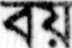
বয়
